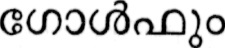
ഗോള്‍ഫും
